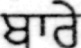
ਬਾਰੇ
